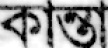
কান্তা
